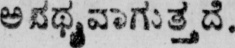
ಅಪಥ್ಯವಾಗುತ್ತದೆ.
